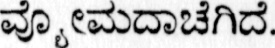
ವ್ಯೋಮದಾಚೆಗಿದೆ.
